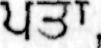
ਪਤਾ,
